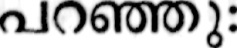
പറഞ്ഞു:
